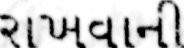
રાખવાની
